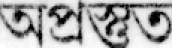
অপ্রস্তুত
